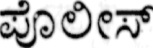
ಪೊಲೀಸ್
